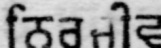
ਨਿਰਜੀਵ
